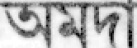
অমদা
